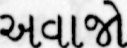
અવાજો
